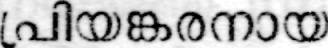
പ്രിയങ്കരനായ
